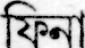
ফিনা
